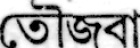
তৌজবা
